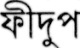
ফীদুপ
